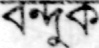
বন্দুক
